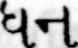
ધન
